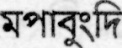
মপাবুংদি
